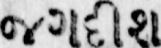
જગદીશ
